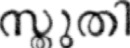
സ്തുതി
